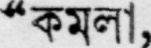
‘‘কমলা,
